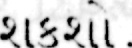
શકશો.
